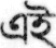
এই
